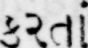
કરતાં
